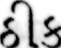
ઠીક
